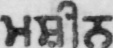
ਮਸ਼ੀਨ
